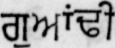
ਗੁਆਂਢੀ
